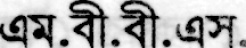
এম.বী.বী.এস.
